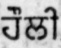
ਹੌਲੀ
